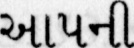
આપની
